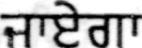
ਜਾਏਗਾ
